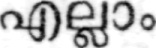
എല്ലാം
